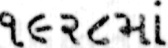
૧૯૨૮માં
